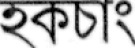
হকচাং
